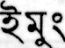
ইমুং
